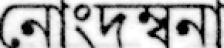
নোংদম্বনা
